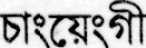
চাংয়েংগী
